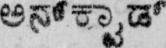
ಅನ್‌ಕ್ಟಾಡ್
